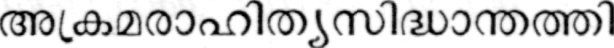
അക്രമരാഹിത്യസിദ്ധാന്തത്തി
